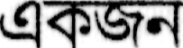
একজন
